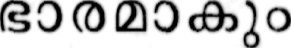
ഭാരമാകും
